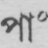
পা
